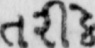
તરીકે
